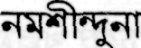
নমশীন্দুনা
